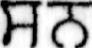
ਸਨ
